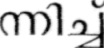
ന്നിച്ച്
